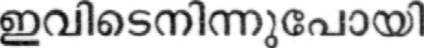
ഇവിടെനിന്നുപോയി
